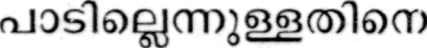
പാടില്ലെന്നുള്ളതിനെ
